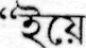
"ইয়ে
